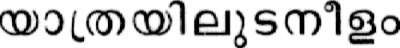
യാത്രയിലുടനീളം
